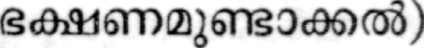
ഭക്ഷണമുണ്ടാക്കല്‍)
